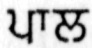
ਪਾਲ
